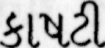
કાષટી
